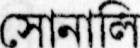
সোনালি
